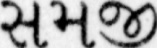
સમજી
